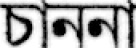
চাননা
